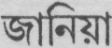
জানিয়া
